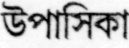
উপাসিকা
